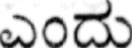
ಎಂದು
